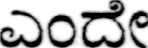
ಎಂದೇ
